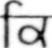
ਕਿ
